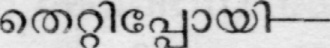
തെറ്റിപ്പോയി-
